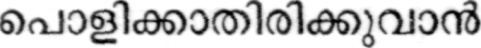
പൊളിക്കാതിരിക്കുവാന്‍
